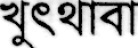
খুৎথাবা
